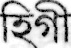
হিগী
